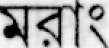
মরাং
